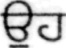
ਉਹ
